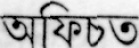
অফিচত
